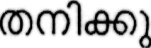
തനിക്കു
